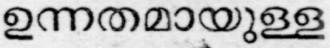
ഉന്നതമായുള്ള
